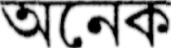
অনেক
